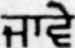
ਜਾਵੇ
